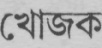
খোজক
